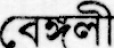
বেঙ্গলী
